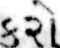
કરો
